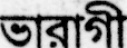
ভারাগী
